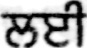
ਲਈ
